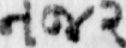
નજર
